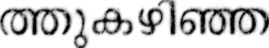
ത്തുകഴിഞ്ഞ
